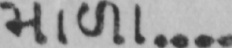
માળા....
